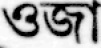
ওজা
